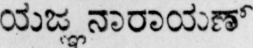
ಯಜ್ಞನಾರಾಯಣ್
